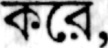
করে,
